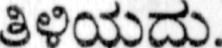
ತಿಳಿಯದು.
